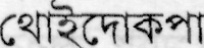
থোইদোকপা
